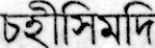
চহীসিমদি
